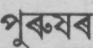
পুৰুষৰ
